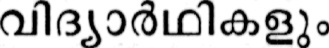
വിദ്യാര്‍ഥികളും
